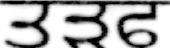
ਤੜਫ
